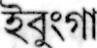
ইবুংগা
